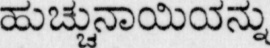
ಹುಚ್ಚುನಾಯಿಯನ್ನು
